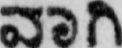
ವಾಗಿ
